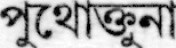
পুথোক্তুনা
